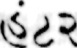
હંટર
